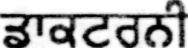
ਡਾਕਟਰਨੀ
